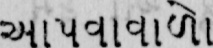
આપવાવાળો
